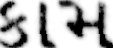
કામ
